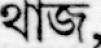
থাজ,
